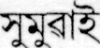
সুমুৱাই
